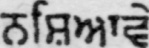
ਨਸ਼ਿਆਵੇ
